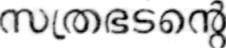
സത്രഭടന്റെ
